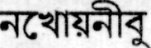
নখোয়নীবু
